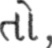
તો,
